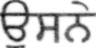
ਉਸਨੇ
